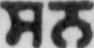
ਸਨ
